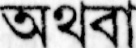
অথবা
